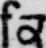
ਕਿ
